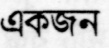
একজন
